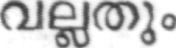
വല്ലതും
